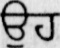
ਉਹ
